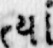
ત્યાં
